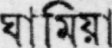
ঘামিয়া
